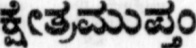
ಕ್ಷೇತ್ರಮುಪ್ತಂ
